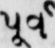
પૂર્વ
